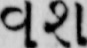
વશ
